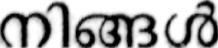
നിങ്ങള്‍
